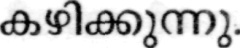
കഴിക്കുന്നു.
